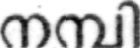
നമ്പി
